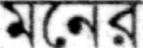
মনের
